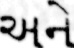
અને
